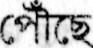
পৌঁছে
